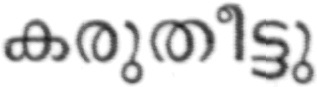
കരുതീട്ടു
